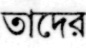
তাদের
